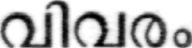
വിവരം
